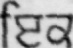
ਇਕ
